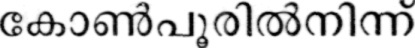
കോണ്‍പൂരില്‍നിന്ന്
